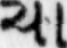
ચા
